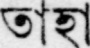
তাহা
